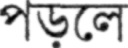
পড়লে
